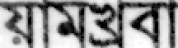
য়ামখ্রবা
